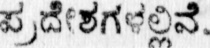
ಪ್ರದೇಶಗಳಲ್ಲಿವೆ.
